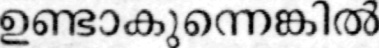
ഉണ്ടാകുന്നെങ്കില്‍
